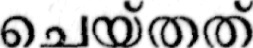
ചെയ്തത്
